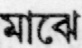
মাঝে
